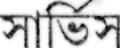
সার্ভিস
